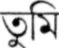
তুমি
